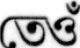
তেওঁ
